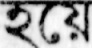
হয়ে
